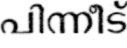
പിന്നീട്
